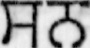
ਸਨ
